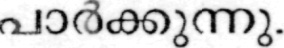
പാര്‍ക്കുന്നു.
